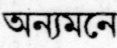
অন্যমনে
